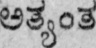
ಅತ್ಯಂತ
